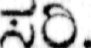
ಸರಿ.
